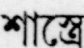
শাস্ত্রে
